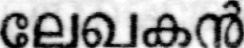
ലേഖകന്‍
